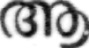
ആ
